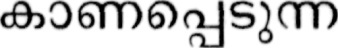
കാണപ്പെടുന്ന
